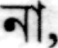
না,
